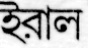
ইরাল
